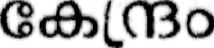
കേന്ദ്രം
